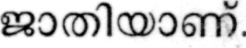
ജാതിയാണ്.
